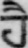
ਹੈ
